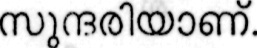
സുന്ദരിയാണ്.
